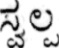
ಸ್ವಲ್ಪ
